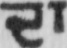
ਦਾ
